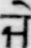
ਜੇ
